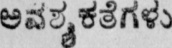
ಅವಶ್ಯಕತೆಗಳು
